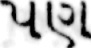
પણ
